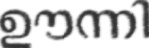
ഊന്നി
